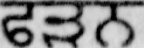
ਫੜਨ
